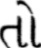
તો
